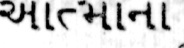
આત્માના
